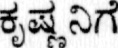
ಕೃಷ್ಣನಿಗೆ
